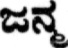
ಜನ್ಮ
